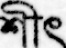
শীৎ
